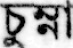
চুম্না
